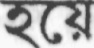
হয়ে
